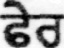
ਫੇਰ
